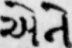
એને
